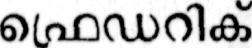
ഫ്രെഡറിക്
